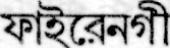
ফাইরেনগী
